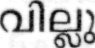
വില്ലു
